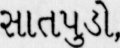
સાતપુડો,
